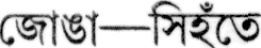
জোঙা-সিহঁতে
